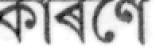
কাৰণে
